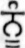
ਨੂੰ
